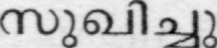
സുഖിച്ചു
